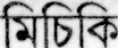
মিচিকি
